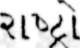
રાષ્ટ્રો
